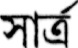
সার্ত্র
